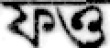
ফত্ত
